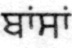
ਬਾਂਸਾਂ
